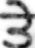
ਤੇ
